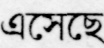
এসেছে
